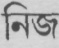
নিজ
